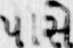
પાસે
